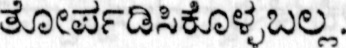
ತೋರ್ಪಡಿಸಿಕೊಳ್ಳಬಲ್ಲ.
